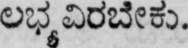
ಲಭ್ಯವಿರಬೇಕು.
